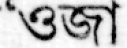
“ওজা
